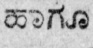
ಹಾಗೂ
